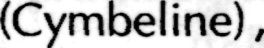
(Cymbeline),
